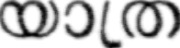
യാത്ര
